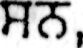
ਸਨ,
